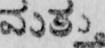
ಮತ್ತು
